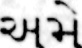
અમે
